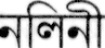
নলিনী
